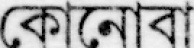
কোনোবা
